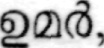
ഉമര്‍,
